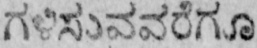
ಗಳಿಸುವವರೆಗೂ
